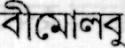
বীমোলবু
